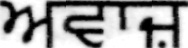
ਅਵਾਜ਼
